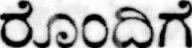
ರೊಂದಿಗೆ
